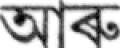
আৰু
